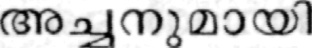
അച്ചനുമായി
